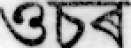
ওচৰ
